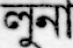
লুনা
